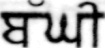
ਬੱਘੀ
